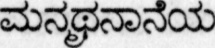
ಮನ್ಮಥನಾನೆಯ
